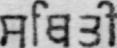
ਸਥਿਤੀ
